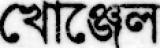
খোঞ্জেল
